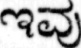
ಇವು
